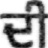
ਦੀ
